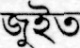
জুইত
